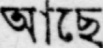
আছে
